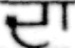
ਦਾ
